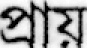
প্রায়
